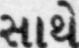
સાથે
